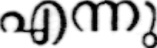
എന്നു
